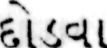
દોડવા
